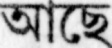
আছে
